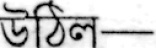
উঠিল-
